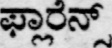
ಫ್ಲಾರೆನ್ಸ್
